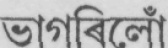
ভাগৰিলোঁ
